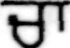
ਚਾ
